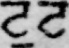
ਟੁਟ
